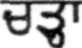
ਚੜ੍ਹਾ
